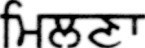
ਮਿਲਣਾ
